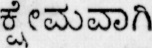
ಕ್ಷೇಮವಾಗಿ
